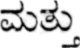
ಮತ್ತು
